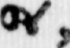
જ
